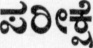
ಪರೀಕ್ಷೆ
